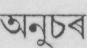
অনুচৰ
